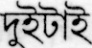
দুইটাই
